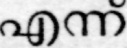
എന്ന്
